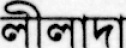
লীলাদা
